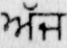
ਅੱਜ
